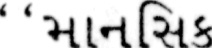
"માનસિક
